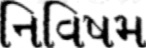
નિવિષમ
